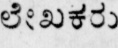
ಲೇಖಕರು
